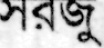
সরজু
